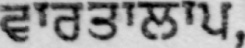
ਵਾਰਤਾਲਾਪ,
